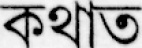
কথাত
